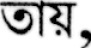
তায়,
